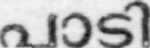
പാടി
